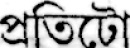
প্রতিটো
